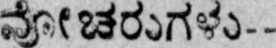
ವೋಚರುಗಳು--
